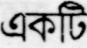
একটি
